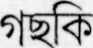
গছকি
